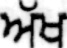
ਅੱਖ
